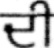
ਦੀ
